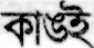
কাঙই
